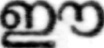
ഈ
